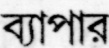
ব্যাপার
